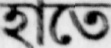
হাতে
